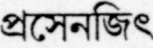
প্রসেনজিত্
